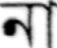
না
